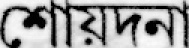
শোয়দনা
